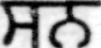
ਸਨ
